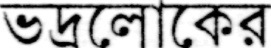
ভদ্রলোকের
